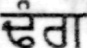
ਢੰਗ
